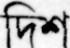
দিশ
